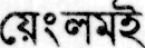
য়েংলমই
